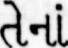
તેનાં
